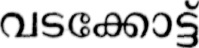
വടക്കോട്ട്
